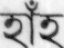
হাঁহ
